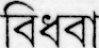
বিধবা
